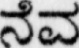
ನೆವ
